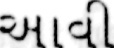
આવી
